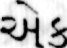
એક
